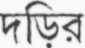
দড়ির
